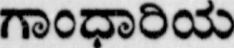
ಗಾಂಧಾರಿಯ
